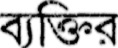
ব্যক্তির
